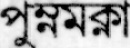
পুম্নমক্না
